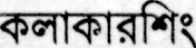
কলাকারশিং
